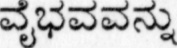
ವೈಭವವನ್ನು
